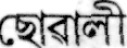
ছোৱালী
